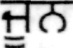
ਜੂਨ
